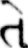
તે
